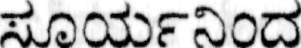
ಸೂರ್ಯನಿಂದ
